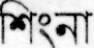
শিংনা
